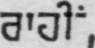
ਰਾਹੀਂ,
